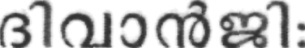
ദിവാന്‍ജി:
